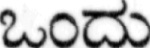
ಒಂದು
